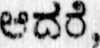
ಆದರೆ,
